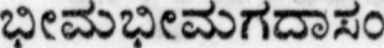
ಭೀಮಭೀಮಗದಾಸಂ
